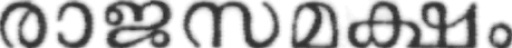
രാജസമക്ഷം
